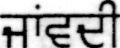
ਜਾਂਵਦੀ
